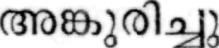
അങ്കുരിച്ചു
